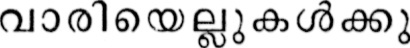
വാരിയെല്ലുകള്‍ക്കു
